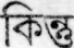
কিন্তু
